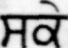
ਸਕੇ
